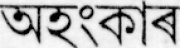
অহংকাৰ
